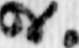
જ.
